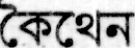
কৈথেন
